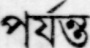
পর্যন্ত
